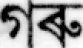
গৰু
